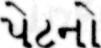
પેટનો
